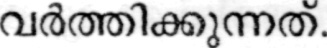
വര്‍ത്തിക്കുന്നത്.
